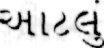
આટલું
